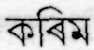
কৰিম
